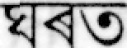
ঘৰত
